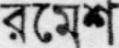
রমেশ
